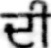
ਦੀ
